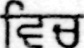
ਵਿਚ
